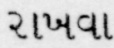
રાખવા
